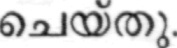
ചെയ്തു.
